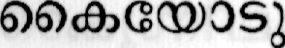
കൈയോടു
